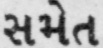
સમેત
